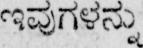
ಇವುಗಳನ್ನು
